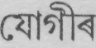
যোগীৰ
